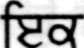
ਇਕ
